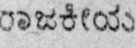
ರಾಜಕೀಯ
